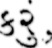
કરું,
